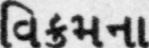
વિક્રમના
